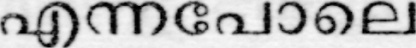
എന്നപോലെ
